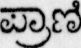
ಪ್ರಾಣಿ
